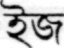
ইজ
